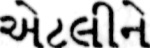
એટલીને
